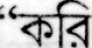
“করি
